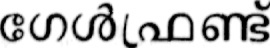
ഗേള്‍ഫ്രണ്ട്
